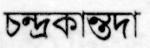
চন্দ্রকান্তদা
